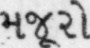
મજૂરો
